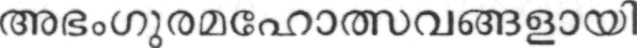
അഭംഗുരമഹോത്സവങ്ങളായി
